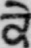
ਕੇ
